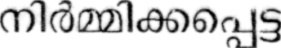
നിര്‍മ്മിക്കപ്പെട്ട
